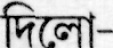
দিলো-
